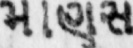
માણસ
